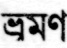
ভ্রমণ
